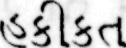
હકીકત
